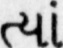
ત્યાં
